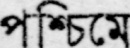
পশ্চিমে
